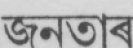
জনতাৰ
